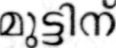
മുട്ടിന്
